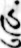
હું
